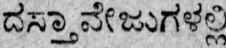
ದಸ್ತಾವೇಜುಗಳಲ್ಲಿ
